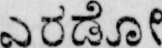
ಎರಡೋ
